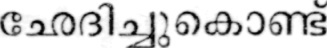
ഛേദിച്ചുകൊണ്ട്
